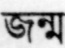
জন্ম
